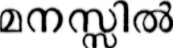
മനസ്സില്‍
